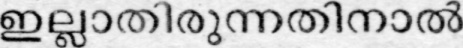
ഇല്ലാതിരുന്നതിനാല്‍
